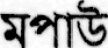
মপাউ
